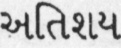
અતિશય
